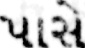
પાસે
